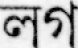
লগ
